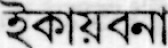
ইকায়বনা
